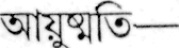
আয়ুষ্মতি-
